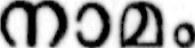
നാമം
